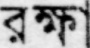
রক্ষা
